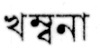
খম্বনা
